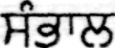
ਸੰਭਾਲ
